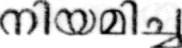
നിയമിച്ച
